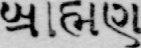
બ્રાહ્મણ
